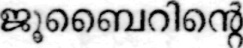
ജൂബൈറിൻ്റേ
